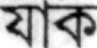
যাক
